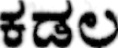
ಕಡಲ
